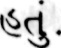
હતું.
